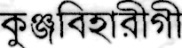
কুঞ্জবিহারীগী
